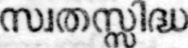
സ്വതസ്സിദ്ധ
